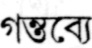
গন্তব্যে
